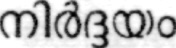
നിര്‍ദ്ദയം
